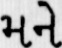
મને
